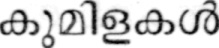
കുമിളകള്‍
